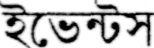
ইভেন্টস
